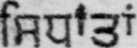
ਸਿਧਾਂਤਾਂ
